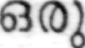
ഒരു
